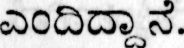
ಎಂದಿದ್ದಾನೆ.
